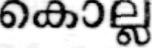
കൊല്ല
